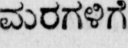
ಮರಗಳಿಗೆ
